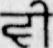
ਵੀ
